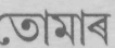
তোমাৰ
